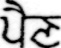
ਪੈਣ
